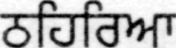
ਠਹਿਰਿਆ
